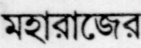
মহারাজের
